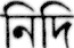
নিদি
